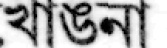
খোঙনা
